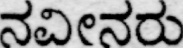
ನವೀನರು
